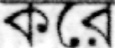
করে
